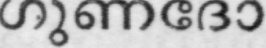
ഗുണദോ
